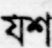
যশ
